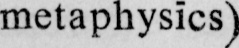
metaphysics)
